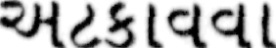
અટકાવવા
